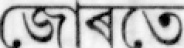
জোৰতে
